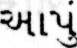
આપું
